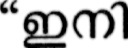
“ഇനി
